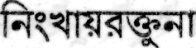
নিংখায়রক্তুনা
